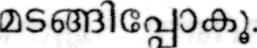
മടങ്ങിപ്പോകൂ.
